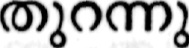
തുറന്നു
